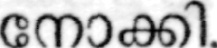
നോക്കി.
